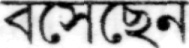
বসেছেন
